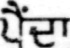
ਪੈਂਦਾ
